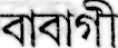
বাবাগী
